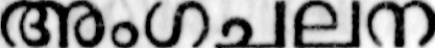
അംഗചലന
